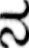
ನ
